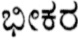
ಭೀಕರ
